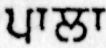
ਪਾਲਾ
